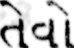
તેવો
